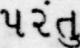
પરંતુ
